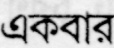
একবার
